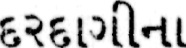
દરદાગીના
